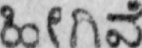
ಹೀಗಿವೆ
